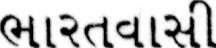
ભારતવાસી
